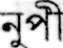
নুপী
